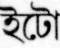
ইটো
